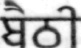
ਬੈਠੀ
